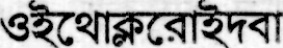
ওইথোক্লরোইদবা
